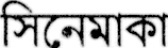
সিনেমাকা
